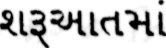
શરૂઆતમાં
